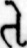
તે
